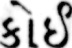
કોઈ
